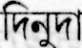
দিনুদা
